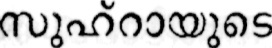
സുഹ്റായുടെ
